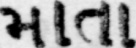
માતા
